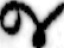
જ
